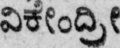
ವಿಕೇಂದ್ರೀ
